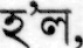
হ'ল,
